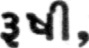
રૂષી,
